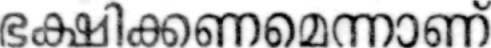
ഭക്ഷിക്കണമെന്നാണ്
